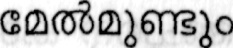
മേല്‍മുണ്ടും
